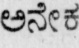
ಅನೇಕ
